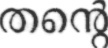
തന്റെ
